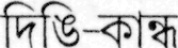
দিঙি-কান্ধ
